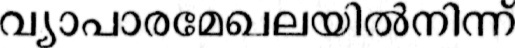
വ്യാപാരമേഖലയില്‍നിന്ന്
